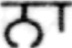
ਨਾ
